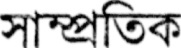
সাম্প্রতিক
